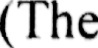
(The
